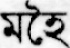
মহৈ
